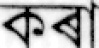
কৰা
